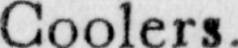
Coolers.
